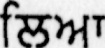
ਲਿਆ
